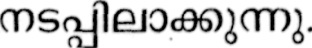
നടപ്പിലാക്കുന്നു.
